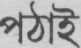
পঠাই
